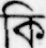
কি
